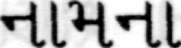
નામના
